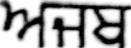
ਅਜਬ
